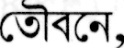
তৌবনে,
